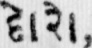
દોરો,
